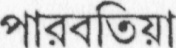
পারবতিয়া
